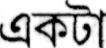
একটা
